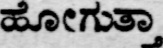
ಹೋಗುತ್ತಾ
